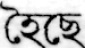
হৈছে
